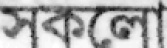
সকলো
